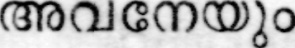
അവനേയും
